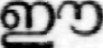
ഈ
